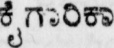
ಕೈಗಾರಿಕಾ
